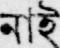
নাই
